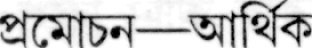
প্রমোচন-আর্থিক
